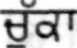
ਚੁੱਕਾ
